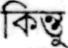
কিন্তু
